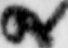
જ
